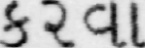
કરવા
